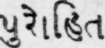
પુરોહિત
